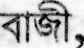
বাজী,
